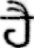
ਹੈ
